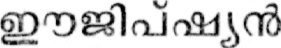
ഈജിപ്ഷ്യന്‍
